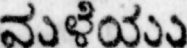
ಮಳೆಯು
